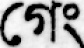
গেং
